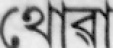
থোৱা
